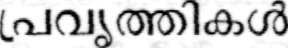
പ്രവൃത്തികള്‍
